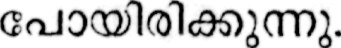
പോയിരിക്കുന്നു.
